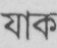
যাক
